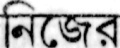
নিজের
